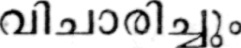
വിചാരിച്ചും
